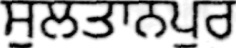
ਸੁਲਤਾਨਪੁਰ
